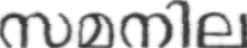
സമനില
